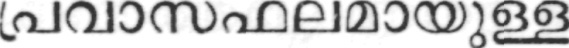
പ്രവാസഫലമായുള്ള
